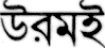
উরমই
